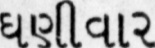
ઘણીવાર
